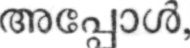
അപ്പോള്‍,
